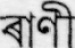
ৰাণী
